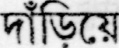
দাঁড়িয়ে
